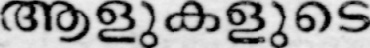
ആളുകളുടെ
